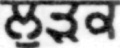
ਲੁੜਕ
